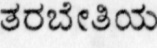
ತರಬೇತಿಯ
